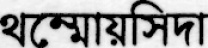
থম্মোয়সিদা
